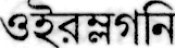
ওইরম্লগনি
